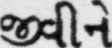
જીવીને
